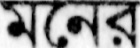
মনের
